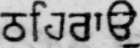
ਠਹਿਰਾਉ
